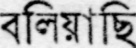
বলিয়াছি
